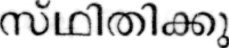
സ്ഥിതിക്കു
